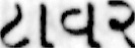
ટાવર
